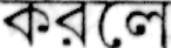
করলে
